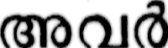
അവര്‍
